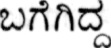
ಬಗೆಗಿದ್ದ
